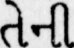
તેની
